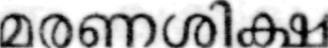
മരണശിക്ഷ
